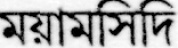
ময়ামসিদি
